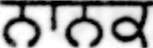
ਨਾਨਕ
